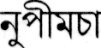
নুপীমচা
